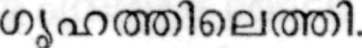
ഗൃഹത്തിലെത്തി.
